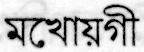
মখোয়গী
